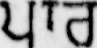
ਪਾਰ
